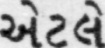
એટલે
